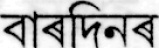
বাৰদিনৰ
